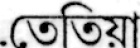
তেতিয়া
